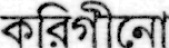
করিগীনো
